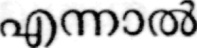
എന്നാല്‍
